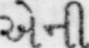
એની
